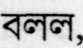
বলল,
